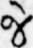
જે
